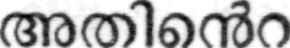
അതിന്റെ
